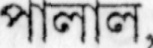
পালাল,
